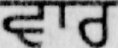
ਵਾਰ
